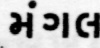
મંગલ
